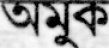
অমুক
